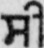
ਸੀ
